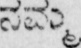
ನಮ್ಮ
